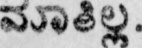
ಮಾತಿಲ್ಲ.
